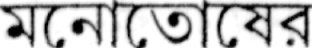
মনোতোষের
